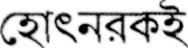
হোৎনরকই
